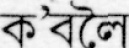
ক'বলৈ
